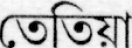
তেতিয়া
